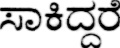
ಸಾಕಿದ್ದರೆ
